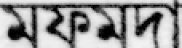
মফমদা
